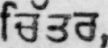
ਚਿੱਤਰ,
